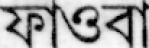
ফাওবা
